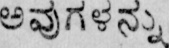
ಅವುಗಳನ್ನು
